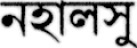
নহালসু
